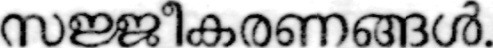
സജ്ജീകരണങ്ങള്‍.
